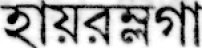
হায়রম্লগা
